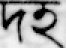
দহ
